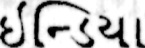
ઈન્ડિયા
